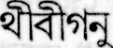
থীবীগনু
